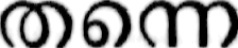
തന്നെ
